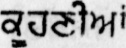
ਕੂਹਣੀਆਂ
